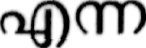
എന്ന
